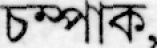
চম্পাক,
